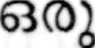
ഒരു
